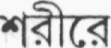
শরীরে
